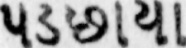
પડછાયા
